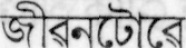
জীৱনটোৱে
